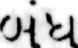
બંધ
